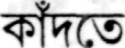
কাঁদতে
